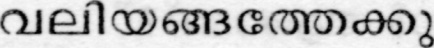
വലിയങ്ങത്തേക്കു
